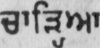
ਚਾੜ੍ਹਿਆ
